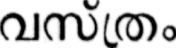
വസ്ത്രം
